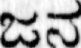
ಜನ
